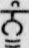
ਨੂੰ
